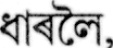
ধাৰলৈ,
